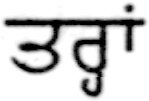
ਤਰ੍ਹਾਂ
